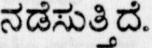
ನಡೆಸುತ್ತಿದೆ.
